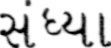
સંધ્યા
